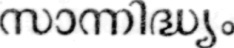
സാന്നിദ്ധ്യം
